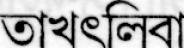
তাখৎলিবা
